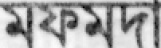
মফমদা
